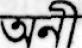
অনী
